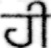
ਹੀ
